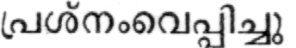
പ്രശ്നംവെപ്പിച്ചു
